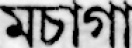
মচাগা
